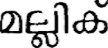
മല്ലിക്
